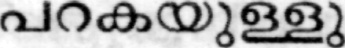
പറകയുള്ളു
